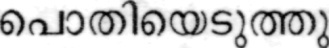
പൊതിയെടുത്തു
